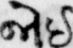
જોઈ
